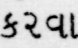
કરવા
